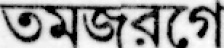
তমজরগে
